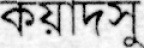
কয়াদসু
